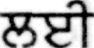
ਲਈ
